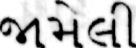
જામેલી
